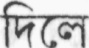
দিলে
